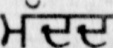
ਮੱਦਦ
